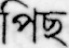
পিছ
